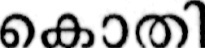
കൊതി
